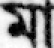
মা
